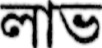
লাভ
